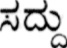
ಸದ್ದು
